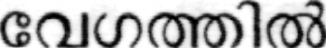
വേഗത്തില്‍
